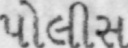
પોલીસ
